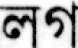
লগ
